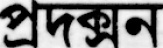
প্রদক্সন
